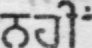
ਨਹੀਂ
